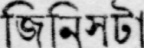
জিনিসটা
